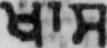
ਖਾਸ
